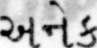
અનેક
